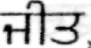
ਜੀਤ,
